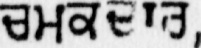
ਚਮਕਦਾਰ,
